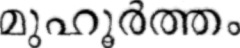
മുഹൂര്‍ത്തം
